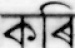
কৰি
